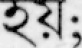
হয়;
